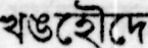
খঙহৌদে
